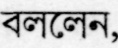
বললেন,
